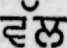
ਵੱਲ
